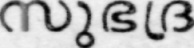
സുഭദ്ര
